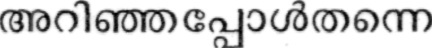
അറിഞ്ഞപ്പോള്‍തന്നെ
